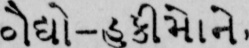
વૈધો-હકીમોને
